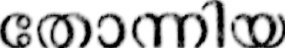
തോന്നിയ
